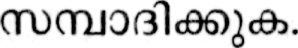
സമ്പാദിക്കുക.
